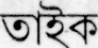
তাইক
